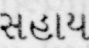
સહાય
